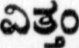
ವಿತ್ತಂ
